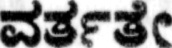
ವರ್ತತೇ
